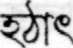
হঠাৎ
